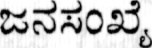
ಜನಸಂಖ್ಯೆ
